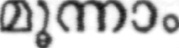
മൂന്നാം
